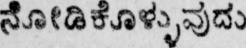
ನೋಡಿಕೊಳ್ಳುವುದು
